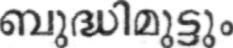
ബുദ്ധിമുട്ടും
